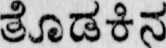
ತೊಡಕಿನ
